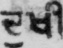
ਦੁਖੀ
